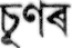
চূণৰ
